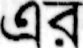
এর
